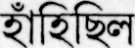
হাঁহিছিল
